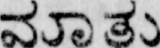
ಮಾತು
